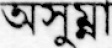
অসুম্না
